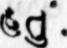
હતું.
